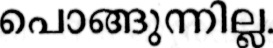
പൊങ്ങുന്നില്ല.
